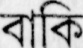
বাকি
